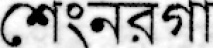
শেংনরগা
